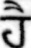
ਹੈ
